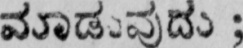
ಮಾಡುವುದು;
